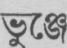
ভুঞ্জে
